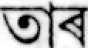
তাৰ
